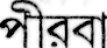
পীরবা
